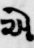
એ
